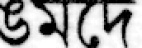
ঙমদে
